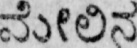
ಮೇಲಿನ
